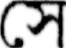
সে
